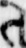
તે
